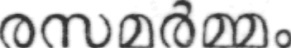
രസമര്‍മ്മം
